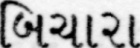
બિચારા
